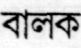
বালক
